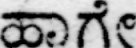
ಹಾಗೇ
